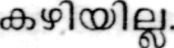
കഴിയില്ല.
